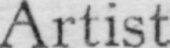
Artist
